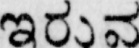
ಇರುವ
